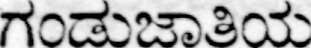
ಗಂಡುಜಾತಿಯ
